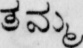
ತಮ್ಮ
